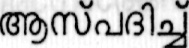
ആസ്പദിച്ച്
